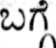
ಬಗ್ಗೆ
